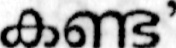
കണ്ട’
